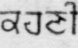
ਕਹਣੀ
